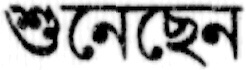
শুনেছেন
